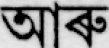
আৰু
